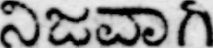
ನಿಜವಾಗಿ
